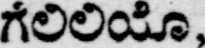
ಗೆಲಿಲಿಯೊ,
